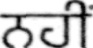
ਨਹੀਂ
